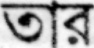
তার
